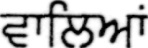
ਵਾਲਿਆਂ
